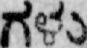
ಗಳು
